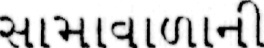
સામાવાળાની
